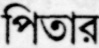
পিতার
